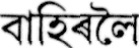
বাহিৰলৈ
